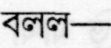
বলল–
